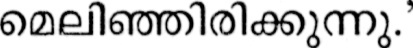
മെലിഞ്ഞിരിക്കുന്നു.’
